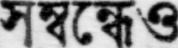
সম্বন্ধেও
